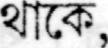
থাকে,
